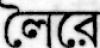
লৈরে
